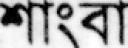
শাংবা
